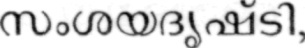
സംശയദൃഷ്ടി,
